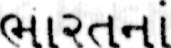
ભારતનાં
